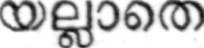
യല്ലാതെ
